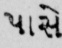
પાસે
